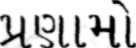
પ્રણામો
